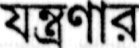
যন্ত্রণার
